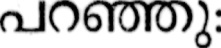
പറഞ്ഞു:
